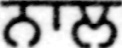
ਨਾਲ
